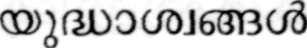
യുദ്ധാശ്വങ്ങള്‍
